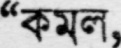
‘‘কমল,
